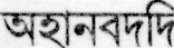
অহানবদদি
